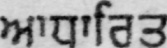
ਆਧਾਰਿਤ
